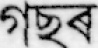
গছৰ
